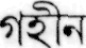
গহীন
